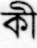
কী
